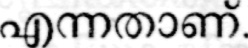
എന്നതാണ്.
